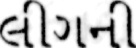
લીગની
